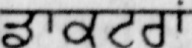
ਡਾਕਟਰਾਂ
